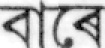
বাৰে
